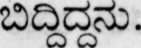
ಬಿದ್ದಿದ್ದನು.
